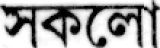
সকলো
